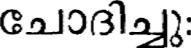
ചോദിച്ചു:
